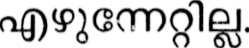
എഴുന്നേറ്റില്ല.
